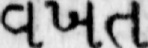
વખત
